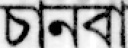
চানবা
